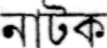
নাটক
